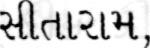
સીતારામ,
